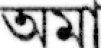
অমা
